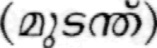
(മുടന്ത്)
